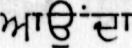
ਆਉਂਦਾ
